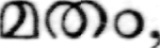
മതം,
